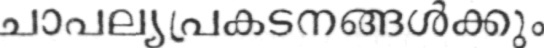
ചാപല്യപ്രകടനങ്ങള്‍ക്കും
